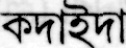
কদাইদা
